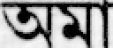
অমা
